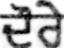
ਦੌਰੇ
